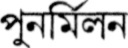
পুনর্মিলন
